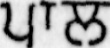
ਪਾਲ
